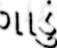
ગાડું
